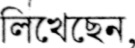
লিখেছেন,
